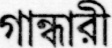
গান্ধারী
